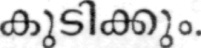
കുടിക്കും.
